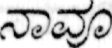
ನಾವೂ
